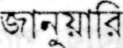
জানুয়ারি
